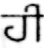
ਹੀ
